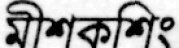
মীশকশিং
